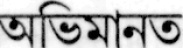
অভিমানত
